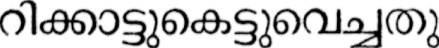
റിക്കാട്ടുകെട്ടുവെച്ചതു
